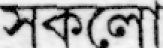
সকলো
